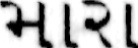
મારા
